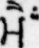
ਮੈਂ
